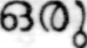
ഒരു
